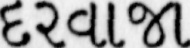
દરવાજા
